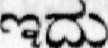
ಇದು
